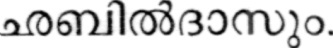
ഛബില്‍ദാസും.
